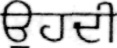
ਉਹਦੀ
